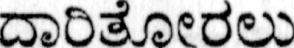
ದಾರಿತೋರಲು
